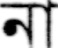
না
